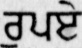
ਰੁਪਏ
